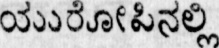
ಯುರೋಪಿನಲ್ಲಿ
